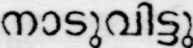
നാടുവിട്ടു
